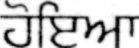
ਹੋਇਆ
